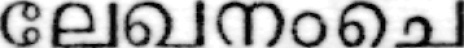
ലേഖനംചെ
